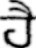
ਹੈ
